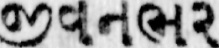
જીવનભર
